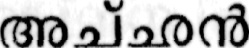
അച്ഛന്‍
